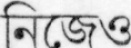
নিজেও
